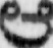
ಆ
